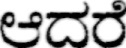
ಆದರೆ
